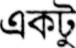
একটু
